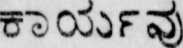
ಕಾರ್ಯವು
